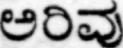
ಅರಿವು
